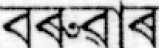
বৰুৱাৰ
